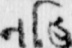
નહિ
